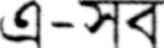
এ-সব
